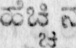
ಹೆಚ್ಚಿನ
